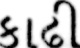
કાઢી
